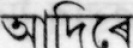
আদিৰে
